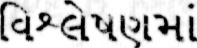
વિશ્લેષણમાં
